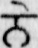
ਨੇ
